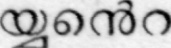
യ്യന്റെ
